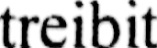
treibit
